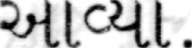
આવ્યા.
